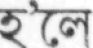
হ'লে
